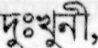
দুঃখুনী,
